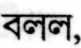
বলল,
